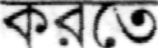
করতে
